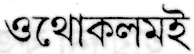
ওথোকলমই
